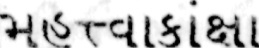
મહત્ત્વાકાંક્ષા
